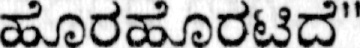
ಹೊರಹೊರಟಿದೆ”
